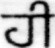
ਹੀ
